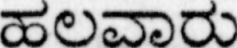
ಹಲವಾರು
